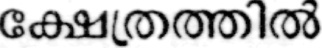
ക്ഷേത്രത്തില്‍
